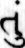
તું
